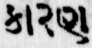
કારણ
